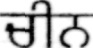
ਚੀਨ
